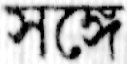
সঙ্গে
